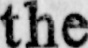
the
